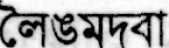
লৈঙমদবা
